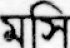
মসি
